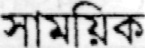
সাময়িক
